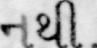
નથી.
